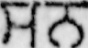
ਸਨ
